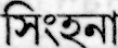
সিংহনা
